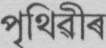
পৃথিৱীৰ
